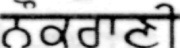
ਨੌਕਰਾਣੀ
